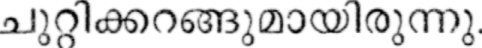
ചുറ്റിക്കറങ്ങുമായിരുന്നു.
